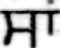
ਸਾਂ
